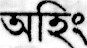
অহিং
